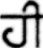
ਹੀ
